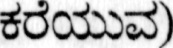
ಕರೆಯುವ)
